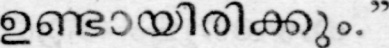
ഉണ്ടായിരിക്കും.''
